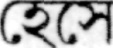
হেসে
